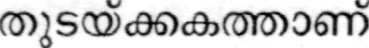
തുടയ്ക്കകത്താണ്
